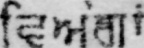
ਵਿਅੰਗਾਂ
